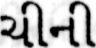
ચીની
